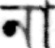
না
